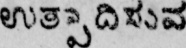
ಉತ್ಪಾದಿಸುವ
